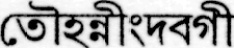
তৌহন্নীংদবগী
